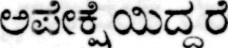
ಅಪೇಕ್ಷೆಯಿದ್ದರೆ
